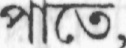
পাতে,
